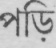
পড়ি
